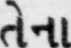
તેના
